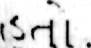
હતો.
